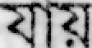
যায়
